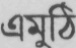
এমুঠি
